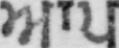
ਆਪ
